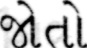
જોતો
